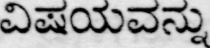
ವಿಷಯವನ್ನು
